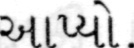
આપ્યો.
